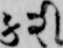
કરી
